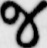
જ
